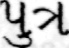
પુત્ર
